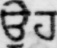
ਉਹ
